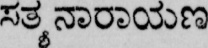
ಸತ್ಯನಾರಾಯಣ
